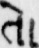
તો
